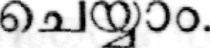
ചെയ്യാം.
